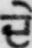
ਦੇ
